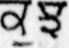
ਕੁਝ
